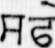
ਸਫੇ
